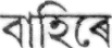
বাহিৰে
